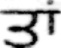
ਤਾਂ
